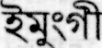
ইমুংগী
